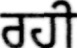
ਰਹੀ
